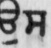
ਉੁਸ
